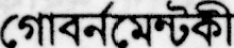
গোবর্নমেন্টকী
